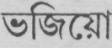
ভজিয়ো
